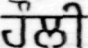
ਹੌਲੀ
